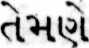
તેમણે
